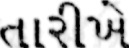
તારીખે
